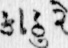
કાઠુરે
